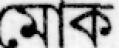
মোক
